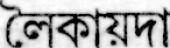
লৈকায়দা
